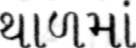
થાળમાં
